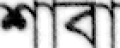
শাবা
